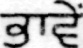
ਭਾਵੇਂ
